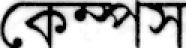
কেম্পস
